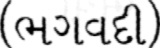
(ભગવદી)
